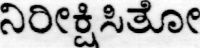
ನಿರೀಕ್ಷಿಸಿತೋ
